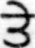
ਤੇ
